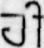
ਹੀ
